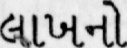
લાખનો
